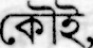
কৌই,
